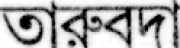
তারুবদা
